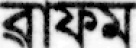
ৱাফম
